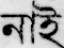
নাই
